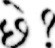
છ?
